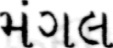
મંગલ
